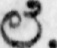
ಲೆ.
